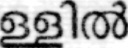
ള്ളില്‍
